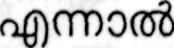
എന്നാല്‍
